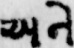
અને
